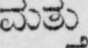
ಮತ್ತು
